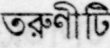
তরুণীটি
